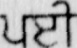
ਪਈ
